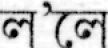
ল'লে
